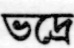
ভদ্রে
